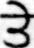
ਤੇ
